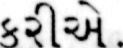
કરીએ.
